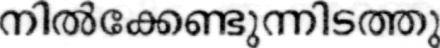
നില്‍ക്കേണ്ടുന്നിടത്തു
